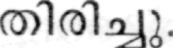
തിരിച്ചു.
